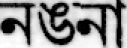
নঙনা
